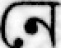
নে
